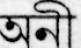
অনী
